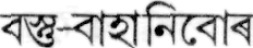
বস্তু-বাহানিবোৰ
